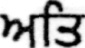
ਅਤਿ
